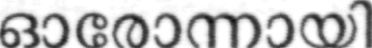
ഓരോന്നായി
